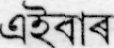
এইবাৰ
